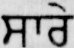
ਸਾਰੇ
